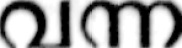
വന്ന
